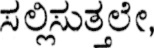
ಸಲ್ಲಿಸುತ್ತಲೇ,
